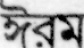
ঈরম
